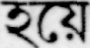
হয়ে
